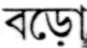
বড়ো
